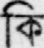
কি
